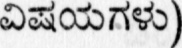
ವಿಷಯಗಳು)
